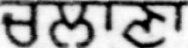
ਚਲਾਣਾ
